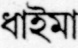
ধাইমা
